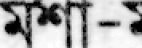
মশা
